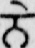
ਨੇ
